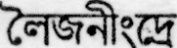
লৈজনীংদ্রে
